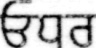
ਓਧਰ
